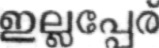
ഇല്ലപ്പേര്
